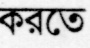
করতে
